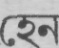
হেন
